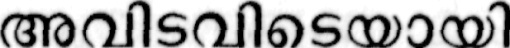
അവിടവിടെയായി
